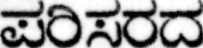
ಪರಿಸರದ
